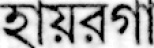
হায়রগা
